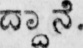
ದ್ದಾನೆ.
